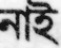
নাই
